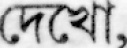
দেখো,
